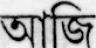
আজি
